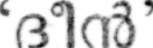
'ദീന്‍'
